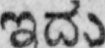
ಇದು
